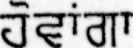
ਹੋਵਾਂਗਾ
